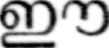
ഈ
